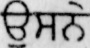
ਉਸਨੇ
